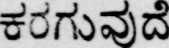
ಕರಗುವುದೆ
